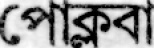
পোক্লবা
